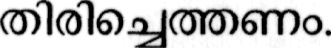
തിരിച്ചെത്തണം.
